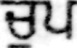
ਚੁਪ
